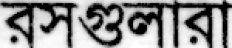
রসগুলারা
